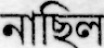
নাছিল
